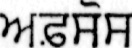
ਅਫ਼ਸੋਸ
